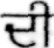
ਦੀ
